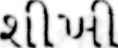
શીખી
